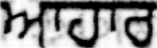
ਆਹਾਰ
